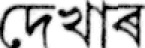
দেখাৰ
